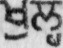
ਖੁਲ੍ਹ
